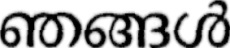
ഞങ്ങള്‍
